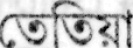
তেতিয়া
